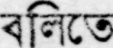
বলিতে
